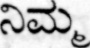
ನಿಮ್ಮ
